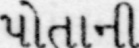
પોતાની
